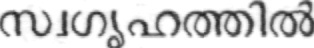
സ്വഗൃഹത്തില്‍
